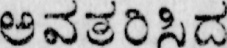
ಅವತರಿಸಿದ
